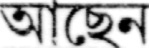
আছেন
